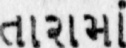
તારામાં
